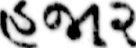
હજાર
